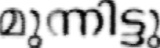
മുന്നിട്ടു
